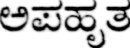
ಅಪಹೃತ
